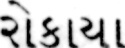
રોકાયા
